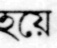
হয়ে
